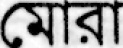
মোরা
